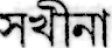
সখীনা
